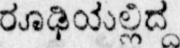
ರೂಢಿಯಲ್ಲಿದ್ದ
